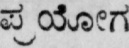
ಪ್ರಯೋಗ
